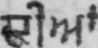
ਦੀਆਂ
